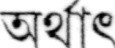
অর্থাত্
